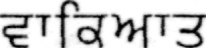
ਵਾਕਿਆਤ
